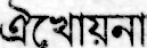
ঐখোয়না
